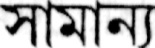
সামান্য
